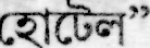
হোটেল”
